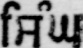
ਸਿੰਘ
